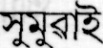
সুমুৱাই
